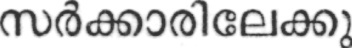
സര്‍ക്കാരിലേക്കു
